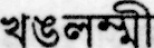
খঙলম্মী
